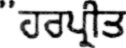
''ਹਰਪ੍ਰੀਤ
